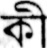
কী
